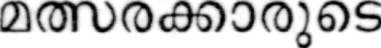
മത്സരക്കാരുടെ
